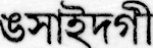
ঙসাইদগী
